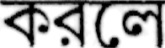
করলে
